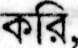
করি,
